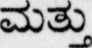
ಮತ್ತು
